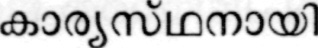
കാര്യസ്ഥനായി
